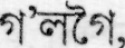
গ'লগৈ,
